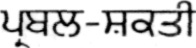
ਪ੍ਰਬਲ-ਸ਼ਕਤੀ
